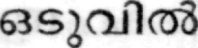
ഒടുവില്‍
